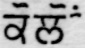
ਕੋਲੋਂ
